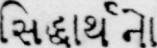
સિદ્ધાર્થનો
